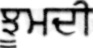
ਝੂਮਦੀ
